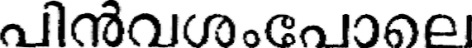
പിന്‍വശംപോലെ
